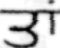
ਤਾਂ
